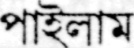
পাইলাম
